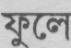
ফুলে
